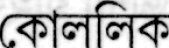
কোললিক
